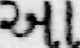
આ
